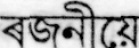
ৰজনীয়ে
